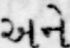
અને
